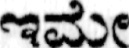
ಇಮೇ
